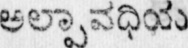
ಅಲ್ಪಾವಧಿಯ
